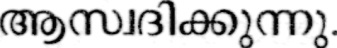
ആസ്വദിക്കുന്നു.
